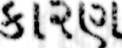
કારણ
